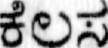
ಕೆಲಸ
